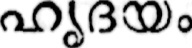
ഹൃദയം
